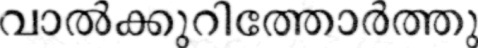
വാല്‍ക്കുറിത്തോര്‍ത്തു
